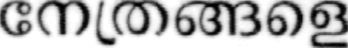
നേത്രങ്ങളെ
